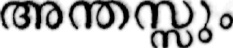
അന്തസ്സും
